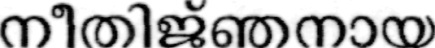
നീതിജ്ഞനായ
